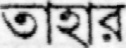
তাহার
